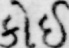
કોઈ
